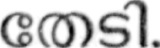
തേടി.
